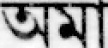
অমা
